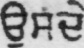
ਉਸਦੇ
